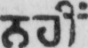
ਨਹੀਂ
